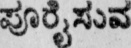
ಪೂರೈಸುವ
